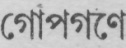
গোপগণে
